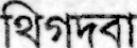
থিগদবা
